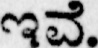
ಇವೆ.
